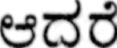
ಆದರೆ
